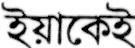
ইয়াকেই
